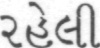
રહેલી
